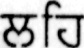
ਲਹਿ
